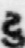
ટુ
